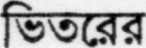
ভিতরের
